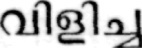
വിളിച്ച
